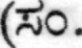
(ಸಂ.
